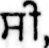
ਸੀ,
